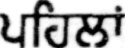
ਪਹਿਲਾਂ
